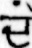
ਦੇ
